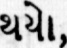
થયો,
